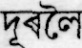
দূৰলৈ
